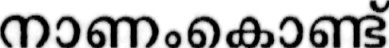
നാണംകൊണ്ട്
